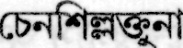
চেনশিল্লক্তুনা
